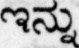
ಇನ್ನು
